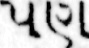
પણ
